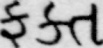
ફક્ત
